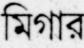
মিগার
